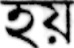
হয়
